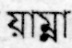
য়াম্না
